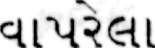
વાપરેલા
